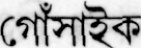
গোঁসাইক
